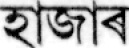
হাজাৰ
